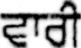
ਵਾਰੀ
